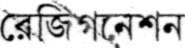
রেজিগনেশন
